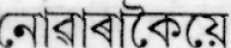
নোৱাৰাকৈয়ে
